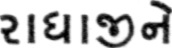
રાધાજીને
